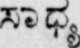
ಸಾಧ್ಯ
